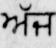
ਅੱਜ
